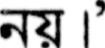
নয়।'
